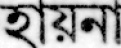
হায়না
